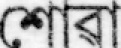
শোৱা
